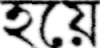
হয়ে
